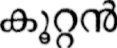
കൂറ്റന്‍
